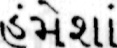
હંમેશાં
